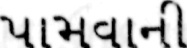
પામવાની
